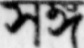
সঙ্গ
